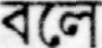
বলে
